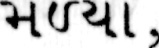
મળ્યા,
